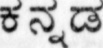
ಕನ್ನಡ
